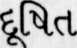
દૂષિત
